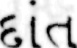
દાંત
